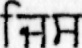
ਜਿਸ
